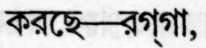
করছে–রগ্গা,
